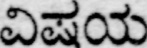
ವಿಷಯ
